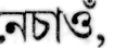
নেচাওঁ,
